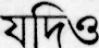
যদিও
